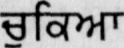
ਚੁਕਿਆ
